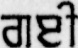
ਗਈ
